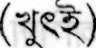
(খুৎই)
